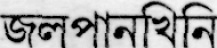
জলপানখিনি
